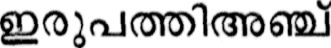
ഇരുപത്തിഅഞ്ച്
